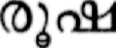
രൂഷ
